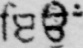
ਇਉਂ
